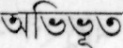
অভিভূত
